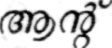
ആന്റ്
